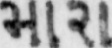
મારા
